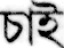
চাই
